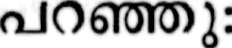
പറഞ്ഞു:
